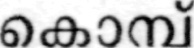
കൊമ്പ്
